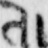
તો
